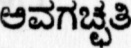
ಅವಗಚ್ಛತಿ
